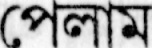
পেলাম
